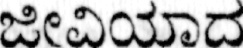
ಜೀವಿಯಾದ
